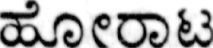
ಹೋರಾಟ
